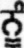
ਨੂੰ
